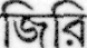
জিরি
